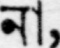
না,
